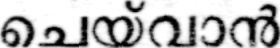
ചെയ്വാന്‍
